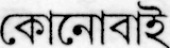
কোনোবাই
